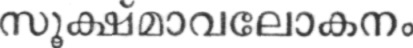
സൂക്ഷ്മാവലോകനം
